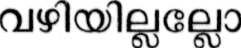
വഴിയില്ലല്ലോ
